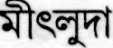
মীৎলুদা
